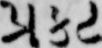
પ્રકટ
